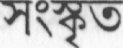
সংস্কৃত
